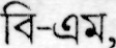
বি-এম,
